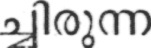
ച്ചിരുന്ന
